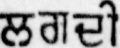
ਲਗਦੀ
